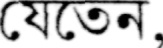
যেতেন,
